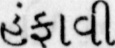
હંફાવી
